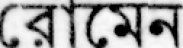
রোমেন
